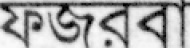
ফজরবা
